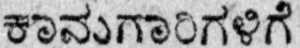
ಕಾಮಗಾರಿಗಳಿಗೆ
